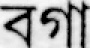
বগা
